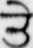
ਤੇ
